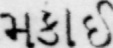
મકાઈ
